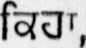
ਕਿਹਾ,
